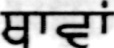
ਥਾਵਾਂ
